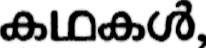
കഥകള്‍,
